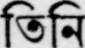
তিনি
